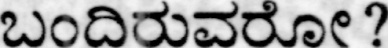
ಬಂದಿರುವರೋ?
